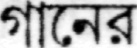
গানের
